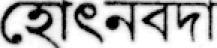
হোৎনবদা
